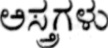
ಅಸ್ತ್ರಗಳು
